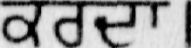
ਕਰਦਾ।
